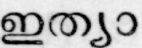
ഇത്യാ
